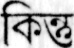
কিন্তু
